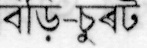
বিড়ি-চুৰট
